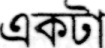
একটা
